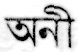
অনী
